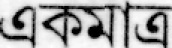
একমাত্র
